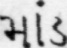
માંડ
